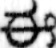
ಈ
